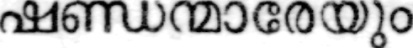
ഷണ്ഡന്മാരേയും
